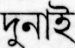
দুনাই
